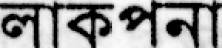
লাকপনা
